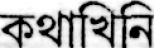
কথাখিনি
